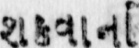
શકવાનાં
